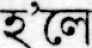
হ'লে
